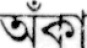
অঁকা
